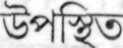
উপস্থিত
